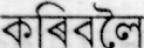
কৰিবলৈ
